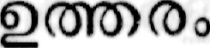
ഉത്തരം
